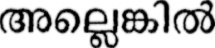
അല്ലെങ്കില്‍
